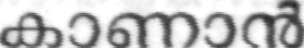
കാണാന്‍
